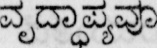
ವೃದ್ಧಾಪ್ಯವೂ
